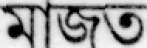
মাজত
